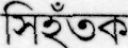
সিহঁতক
